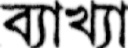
ব্যাখ্যা
